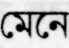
মেনে
